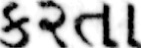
કરતા
